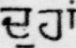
ਦੁਹਾਂ
